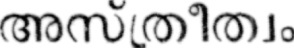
അസ്ത്രീത്വം
